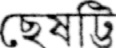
ছেষট্টি
